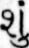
શું
